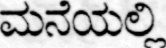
ಮನೆಯಲ್ಲಿ
